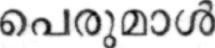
പെരുമാള്‍
